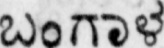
ಬಂಗಾಳ
